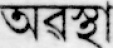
অৱস্হা
